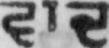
ਵਾਦ
